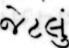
જેટલું
